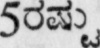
5ರಷ್ಟು
